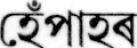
হেঁপাহৰ
